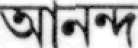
আনন্দ
